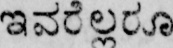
ಇವರೆಲ್ಲರೂ
